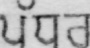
ਪੱਧਰ
